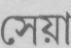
সেয়া
